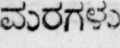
ಮರಗಳು
